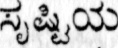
ಸೃಷ್ಟಿಯ
